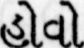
હોવો
